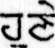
ਹੁਣੇ
